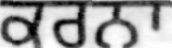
ਕਰਨਾ
